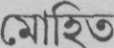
মোহিত
